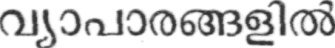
വ്യാപാരങ്ങളില്‍
